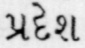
પ્રદેશ
